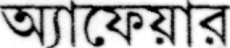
অ্যাফেয়ার
